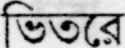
ভিতরে
